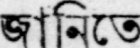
জানিতে
